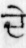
ਦੇ
